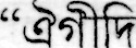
“ঐগীদি
